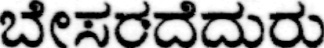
ಬೇಸರದೆದುರು
